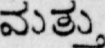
ಮತ್ತು
